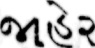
જાહેર
